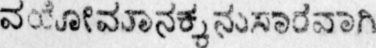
ವಯೋಮಾನಕ್ಕನುಸಾರವಾಗಿ
